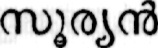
സൂര്യന്‍
